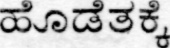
ಹೊಡೆತಕ್ಕೆ
